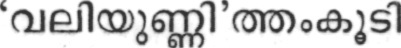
'വലിയുണ്ണി'ത്തംകൂടി
